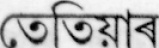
তেতিয়াৰ
